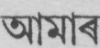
আমাৰ
